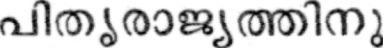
പിതൃരാജ്യത്തിനു
